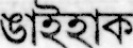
ঙাইহাক
